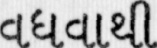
વધવાથી
